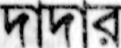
দাদার
